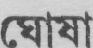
ঘোষা
